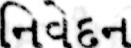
નિવેદન
